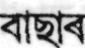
বাছাৰ
